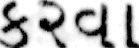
કરવા
